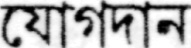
যোগদান
